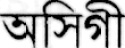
অসিগী
